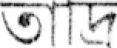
তাদ্রি
